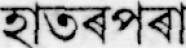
হাতৰপৰা
